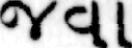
જવા
